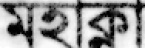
মহাক্না
